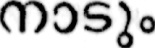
നാടും
